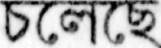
চলেছে
